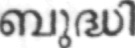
ബുദ്ധി
